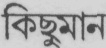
কিছুমান
